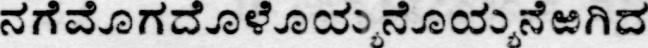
ನಗೆಮೊಗದೊಳೊಯ್ಯನೊಯ್ಯನೆಱಗಿದ
